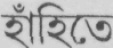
হাঁহিতে
